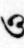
ও
